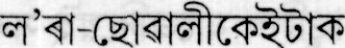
ল'ৰা-ছোৱালীকেইটাক
